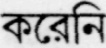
করেনি
